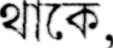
থাকে,
